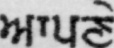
ਆਪਣੇ
